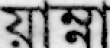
য়াম্না
